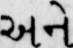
અને
